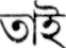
তাই
